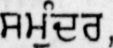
ਸਮੁੰਦਰ,
